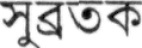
সুব্রতক
